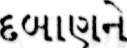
દબાણને
